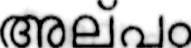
അല്പം
